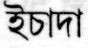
ইচাদা
